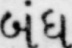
બંધ
